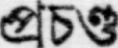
প্রচণ্ড
